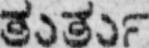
ತುರ್ತು
